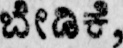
ಬೇಡಿಕೆ,
